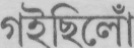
গইছিলোঁ
